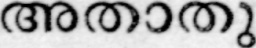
അതാതു
